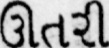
ઊતરી
